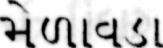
મેળાવડા
